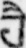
ਹੈ
